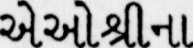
એઓશ્રીના
